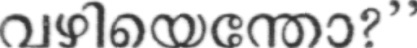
വഴിയെന്തോ?"
